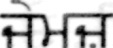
ਜੇਮਜ਼
